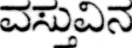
ವಸ್ತುವಿನ
